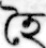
হৈ
